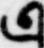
এ
